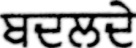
ਬਦਲਦੇ
